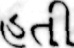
હતી
